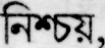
নিশ্চয়,
